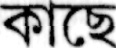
কাছে
